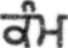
ਕੰਮ
